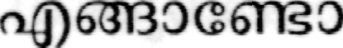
എങ്ങാണ്ടോ
